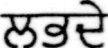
ਲਭਦੇ
